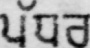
ਪੱਧਰ
